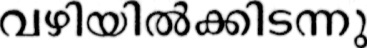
വഴിയില്‍ക്കിടന്നു
